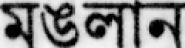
মঙলান
